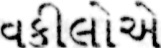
વકીલોએ
